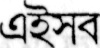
এইসব
